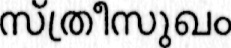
സ്ത്രീസുഖം
